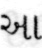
આ
